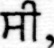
ਸੀ,
